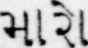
મારો
